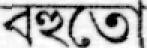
বহুতো
